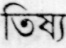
তিষ্য
